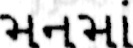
મનમાં
